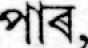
পাৰ,
